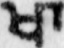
ਖਾ
